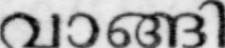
വാങ്ങി
